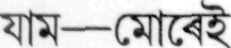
যাম-মোৰেই
